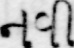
નવી
